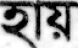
হায়
